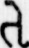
તે
